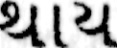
થાય
